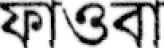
ফাওবা
